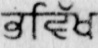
ਭਵਿੱਖ
